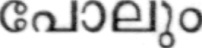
പോലും
